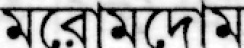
মরোমদোম
